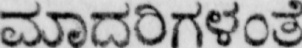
ಮಾದರಿಗಳಂತೆ
